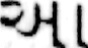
આ
